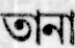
তানা
